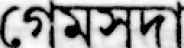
গেমসদা
